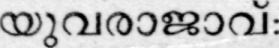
യുവരാജാവ്:
